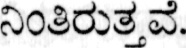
ನಿಂತಿರುತ್ತವೆ.
